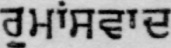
ਰੁਮਾਂਸਵਾਦ
